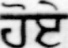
ਹੋਏ
